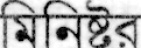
মিনিষ্টর
